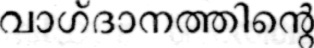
വാഗ്ദാനത്തിന്റെ
